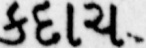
કદાચ
